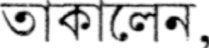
তাকালেন,
